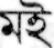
মই
